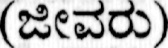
(ಜೀವರು)
